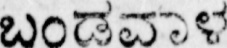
ಬಂಡವಾಳ
